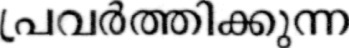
പ്രവര്‍ത്തിക്കുന്ന
